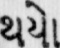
થયો
